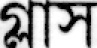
গ্লাস
